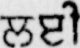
ਲਈ
